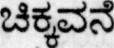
ಚಿಕ್ಕವನೆ
